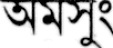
অমসুং
